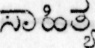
ಸಾಹಿತ್ಯ
